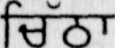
ਚਿੱਠਾ
